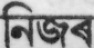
নিজৰ
